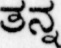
ತನ್ನ
